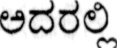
ಅದರಲ್ಲಿ
